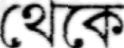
থেকে
